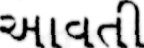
આવતી
